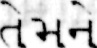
તેમને
